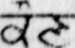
ਕੌਣ
